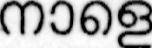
നാളെ
